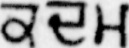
ਕਦਮ
